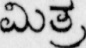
ಮಿತ್ರ
